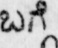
ಬಗ್ಗೆ
